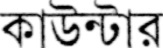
কাউন্টার
